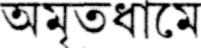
অমৃতধামে
